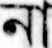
না
